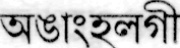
অঙাংহলগী
